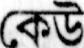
কেউ
